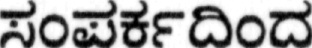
ಸಂಪರ್ಕದಿಂದ
